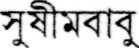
সুষীমবাবু
